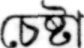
চেষ্টা
